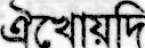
ঐখোয়দি
